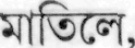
মাতিলে,
